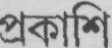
প্ৰকাশি
